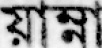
য়াম্না
